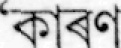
'কাৰণ
